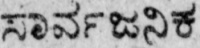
ಸಾರ್ವಜನಿಕ
